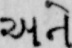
અને
